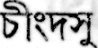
চীংদসু
